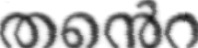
തന്റെ
